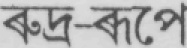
ৰুদ্ৰ-ৰূপে
